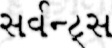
સર્વન્ટ્સ
